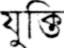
যুক্তি
